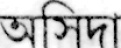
অসিদা
